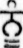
ਨੂੰ
